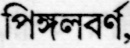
পিঙ্গলবর্ণ,
